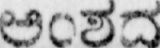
ಅಂಶದ
